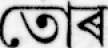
তোৰ
